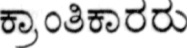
ಕ್ರಾಂತಿಕಾರರು
